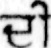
ਦੀ
